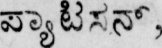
ಪ್ಯಾಟಿಸನ್,
